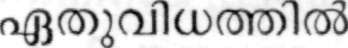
ഏതുവിധത്തില്‍
